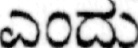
ಎಂದು
